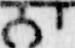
ਨਾ
